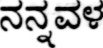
ನನ್ನವಳ
